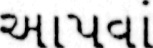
આપવાં
